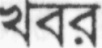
খবর
